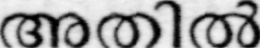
അതില്‍
